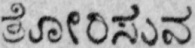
ತೋರಿಸುವ
